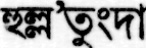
হুল্ল’তুংদা
